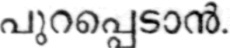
പുറപ്പെടാന്‍.
